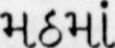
મઠમાં
